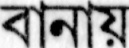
বানায়
